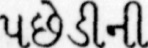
પછેડીની
